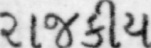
રાજકીય
